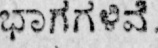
ಭಾಗಗಳಿವೆ.
